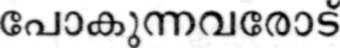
പോകുന്നവരോട്
